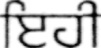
ਇਹੀ
